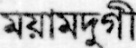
ময়ামদুগী
